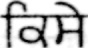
ਕਿਸੇ
